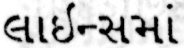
લાઇન્સમાં
